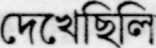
দেখেছিলি
